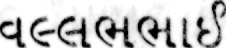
વલ્લભભાઈ
